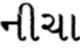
નીચા
